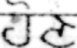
ਹੋਣ
